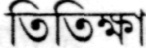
তিতিক্ষা
